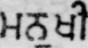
ਮਨੁਖੀ
